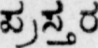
ಪ್ರಸ್ತರ
